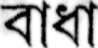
বাধা
